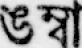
ঙম্বা
